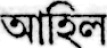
আহিল
